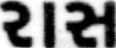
રાસ
